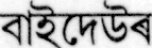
বাইদেউৰ
